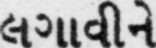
લગાવીને
